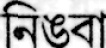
নিঙবা
